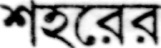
শহরের
